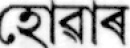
হোৱাৰ
